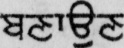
ਬਣਾਉਣ
